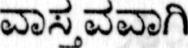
ವಾಸ್ತವವಾಗಿ
